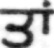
ਤਾਂ
